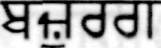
ਬਜ਼ੁਰਗ
